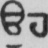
ਉਹ
